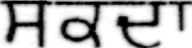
ਸਕਦਾ
